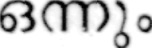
ഒന്നും
